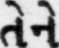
તેને
